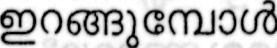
ഇറങ്ങുമ്പോള്‍
